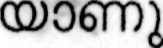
യാണു
